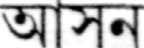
আসন
